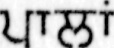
ਪਾਲਾਂ
